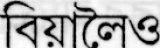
বিয়ালৈও
